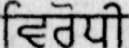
ਵਿਰੋਧੀ
